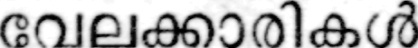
വേലക്കാരികള്‍
